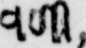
વળી,
